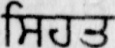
ਸਿਹਤ
